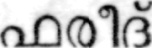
ഫരീദ്
